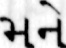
મને
